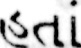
હતાં
